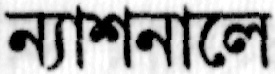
ন্যাশনালে
